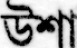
উশা
